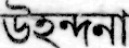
উহন্দনা
